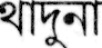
থাদুনা
